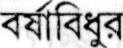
বর্ষাবিধুর
